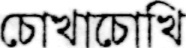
চোখাচোখি
